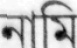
নামি
